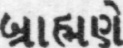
બ્રાહ્મણે
